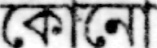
কোনো
